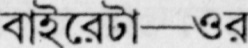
বাইরেটা-ওর
